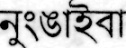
নুংঙাইবা
